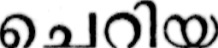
ചെറിയ
